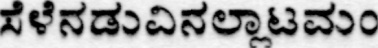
ಸೆಳೆನಡುವಿನಲ್ಲಾಟಮಂ
